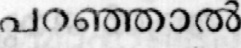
പറഞ്ഞാല്‍
